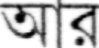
আর
